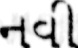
નવી
